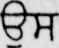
ਉਸ
